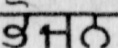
ਭੋਜਨ
